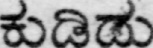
ಕುಡಿದು
